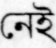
নেই
